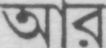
আর
